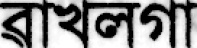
ৱাখলগা
